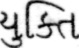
યુક્તિ
